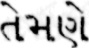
તેમણે
